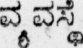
ವ್ಯವಸ್ಥೆ
